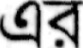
এর
